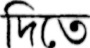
দিতে
